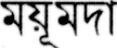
ময়ূমদা
